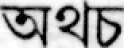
অথচ
